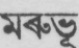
মৰুভূ
